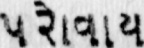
પરોવાય
